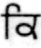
ਕਿ
